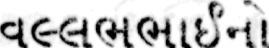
વલ્લભભાઈનો
